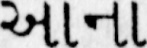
આના
